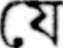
যে
